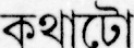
কথাটো
